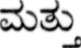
ಮತ್ತು
